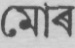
মোৰ
